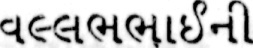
વલ્લભભાઈની
